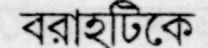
বরাহটিকে
